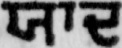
ਯਾਦ
